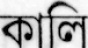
কালি
